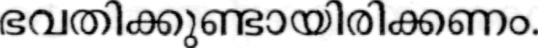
ഭവതിക്കുണ്ടായിരിക്കണം.
